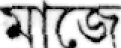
মাজে
